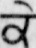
ਕੇ
